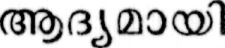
ആദ്യമായി
